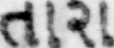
તારા
